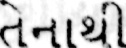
તેનાથી
